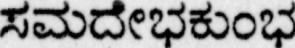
ಸಮದೇಭಕುಂಭ
